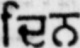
ਦਿਨ
